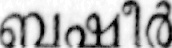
ബഷീര്‍
